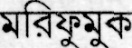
মরিফুমুক
